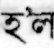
হ'ল
